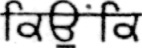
ਕਿਉਂਕਿ
